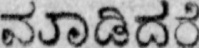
ಮಾಡಿದರೆ
